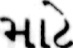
માટે
